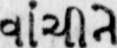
વાંચીને
